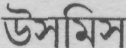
উসমিস
